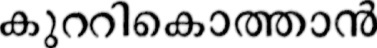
കുററികൊത്താന്‍
